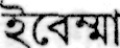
ইবেম্মা
